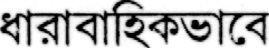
ধারাবাহিকভাবে
